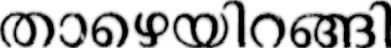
താഴെയിറങ്ങി
